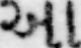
આ
